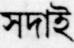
সদাই
